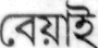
বেয়াই
